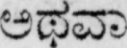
ಅಥವಾ
